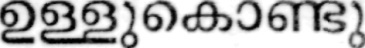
ഉള്ളുകൊണ്ടു
